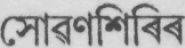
সোৱণশিৰিৰ
